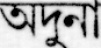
অদুনা
